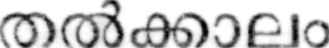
തല്‍ക്കാലം
